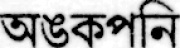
অঙকপনি
